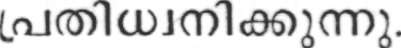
പ്രതിധ്വനിക്കുന്നു.
